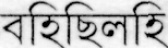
বহিছিলহি
